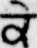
ਕੇ
